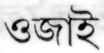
ওজাই
